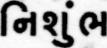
નિશુંભ
